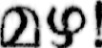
മഴ!
